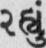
રહ્યું
